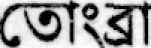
তোংব্রা
